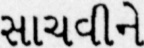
સાચવીને
